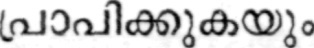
പ്രാപിക്കുകയും
